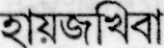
হায়জখিবা
